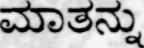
ಮಾತನ್ನು
